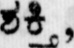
ಶಕ್ತಿ,
